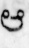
ಆ
